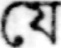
যে
